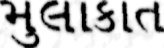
મુલાકાત
